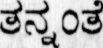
ತನ್ನಂತೆ
